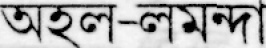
অহল-লমন্দা
